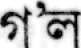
গ'ল
